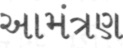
આમંત્રણ
